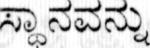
ಸ್ಥಾನವನ್ನು
